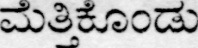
ಮೆತ್ತಿಕೊಂಡು
